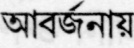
আবর্জনায়
